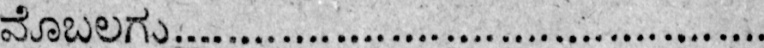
ಮೊಬಲಗು............................................
